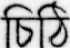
চিঠি
